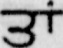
ਤਾਂ
